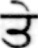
ਤੇ
